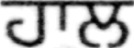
ਹਾਲ
